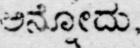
ಅನ್ನೋದು,
